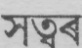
সত্বৰ
